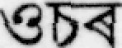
ওচৰ
